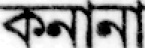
কনানা
